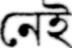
নেই
